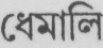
ধেমালি
